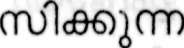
സിക്കുന്ന
